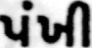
પંખી
